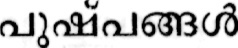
പുഷ്പങ്ങള്‍
